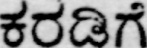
ಕರಡಿಗೆ
